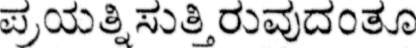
ಪ್ರಯತ್ನಿಸುತ್ತಿರುವುದಂತೂ
